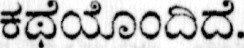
ಕಥೆಯೊಂದಿದೆ.
